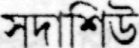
সদাশিউ
